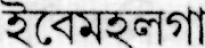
ইবেমহলগা
